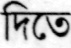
দিতে
